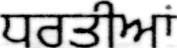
ਧਰਤੀਆਂ
